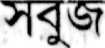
সবুজ
